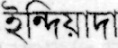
ইন্দিয়াদা
